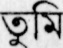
তুমি
